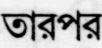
তারপর
